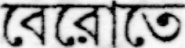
বেরোতে
